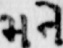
મને
